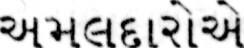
અમલદારોએ
